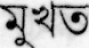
মুখত
